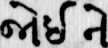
જોઈને
